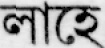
লাহে
